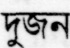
দুজন
